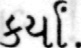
કર્યાં.
